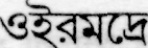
ওইরমদ্রে
